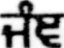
ਜੰਞ
